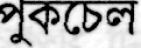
পুকচেল
